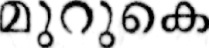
മുറുകെ
